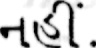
નહીં.
